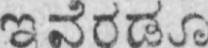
ಇವೆರಡೂ
